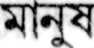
মানুষ
